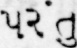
પરંતુ
